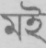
মই
